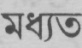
মধ্যত
